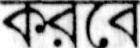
করবে
